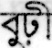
বুঢ়ী
